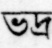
ভদ্র
